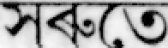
সৰুতে
